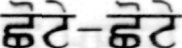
ਛੋਟੇ-ਛੋਟੇ
